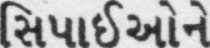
સિપાઈઓને
